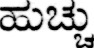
ಹುಚ್ಚು
